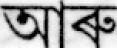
আৰু
